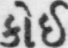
કોઈ
